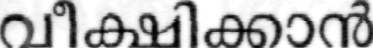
വീക്ഷിക്കാന്‍
